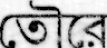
তৌরে
